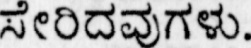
ಸೇರಿದವುಗಳು.
